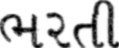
ભરતી
